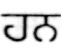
ਹਨ
